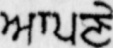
ਆਪਣੇ
